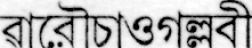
ৱারৌচাওগল্লবী
